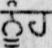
ਨੂੰਹ
